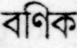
বণিক
